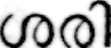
ശരി
